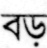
বড়
